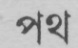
পথ
